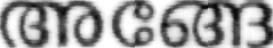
അങ്ങേ
